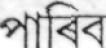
পাৰিব
